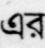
এর
